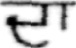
ਦਾ
